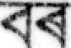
বৰ
